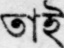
তাই
